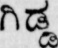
ಗಿಡ್ಡ
